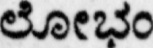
ಲೋಭಂ
